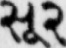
સૂર
